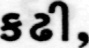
કઢી,
